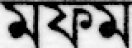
মফম
